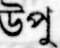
উপু
